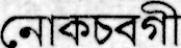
নোকচবগী
